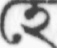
হে
